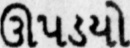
ઊપડયો
